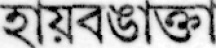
হায়বঙাক্তা
